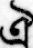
ঐ
